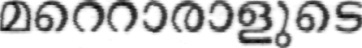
മറ്റൊരാളുടെ
